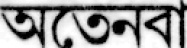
অতেনবা
